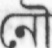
নৌ
